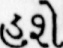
હશે
